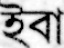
ইবা
